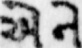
એને
